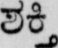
ಶಕ್ತಿ
